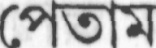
পেতাম
